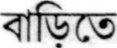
বাড়িতে
